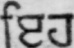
ਇਹ
